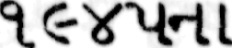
૧૯૪૫ના
